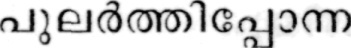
പുലര്‍ത്തിപ്പോന്ന
